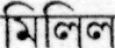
মিলিল
